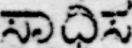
ಸಾಧಿಸ
